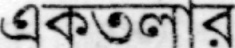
একতলার
